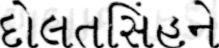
દોલતસિંહને
